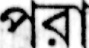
পরা
